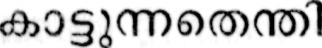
കാട്ടുന്നതെന്തി
